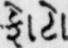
ફોટો
